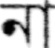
না
